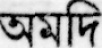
অমদি
